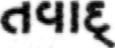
તવાદ્
